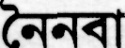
নৈনবা
